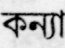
কন্যা
